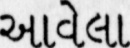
આવેલા
